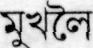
মুখলৈ
